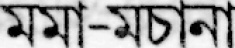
মমা-মচানা
